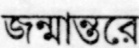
জন্মান্তরে
